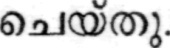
ചെയ്തു.
